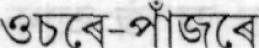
ওচৰে-পাঁজৰে
